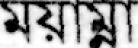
ময়াম্না
